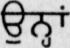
ਉਨ੍ਹਾਂ
